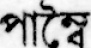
পাম্বৈ
